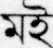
মই
